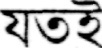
যতই
